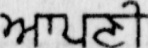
ਆਪਣੀ
